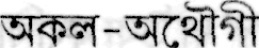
অকল-অথৌগী
